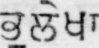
ਭੁਲੇਖਾ
